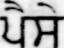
ਪੈਸੇ
